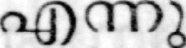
എന്നു
